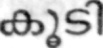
കൂടി
